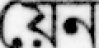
য়েন
